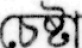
চেষ্টা
